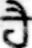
ਹੈ
